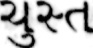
ચુસ્ત
